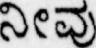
ನೀವು
